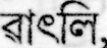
ৱাৎলি,
